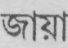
জায়া
